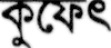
কুফেৎ
